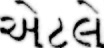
એટલે
